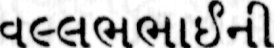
વલ્લભભાઈની
